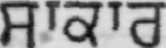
ਸਾਕਾਰ
